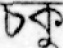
চকু
